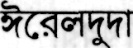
ঈরেলদুদা
